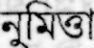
নুমিত্তা
